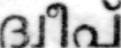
ദ്വീപ്
